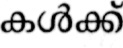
കള്‍ക്ക്
